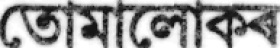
তোমালোকৰ
